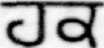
ਹਕ
